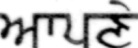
ਆਪਣੇ
